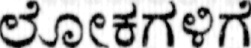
ಲೋಕಗಳಿಗೆ
